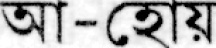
আ-হোয়
